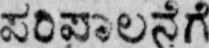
ಪರಿಪಾಲನೆಗೆ
